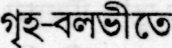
গৃহ-বলভীতে
